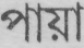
পায়া
